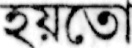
হয়তো
